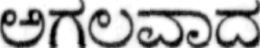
ಅಗಲವಾದ
